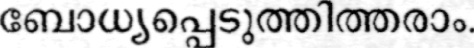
ബോധ്യപ്പെടുത്തിത്തരാം.
